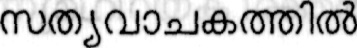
സത്യവാചകത്തില്‍
